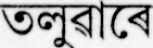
তলুৱাৰে
